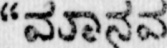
“ಮಾನವ
